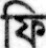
ফি
